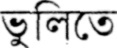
ভুলিতে
